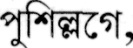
পুশিল্লগে,
